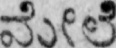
ಮೇಲೆ
